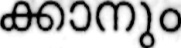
ക്കാനും
